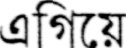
এগিয়ে
